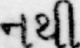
નથી
